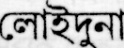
লোইদুনা
